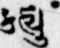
કહ્યું
